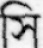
সি
